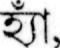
হ্যাঁ,
